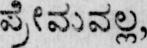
ಪ್ರೇಮವಲ್ಲ,
